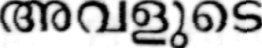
അവളുടെ
